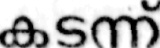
കടന്ന്
